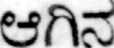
ಆಗಿನ
